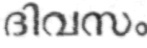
ദിവസം
